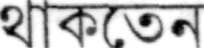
থাকতেন
